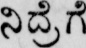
ನಿದ್ರೆಗೆ
